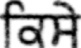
ਕਿਸੇ
